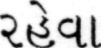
રહેવા
